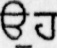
ਉਹ
